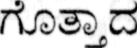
ಗೊತ್ತಾದ
